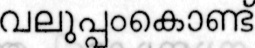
വലുപ്പംകൊണ്ട്
